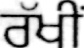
ਰੱਖੀਂ
